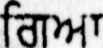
ਗਿਆ
